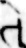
તે
